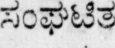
ಸಂಘಟಿತ
